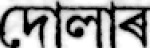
দোলাৰ
